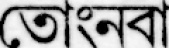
তোংনবা
